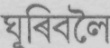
ঘূৰিবলৈ
